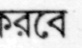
করবে
